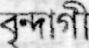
বৃন্দাগী
